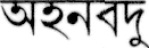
অহনবদু
